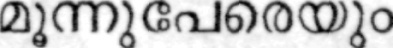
മൂന്നുപേരെയും
